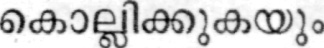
കൊല്ലിക്കുകയും
